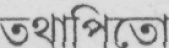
তথাপিতো
